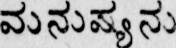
ಮನುಷ್ಯನು
